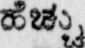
ಹೆಚ್ಚು
